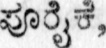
ಪೂರೈಕೆ,
